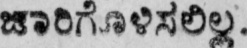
ಜಾರಿಗೊಳಿಸಲಿಲ್ಲ.
